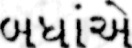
બધાંએ
